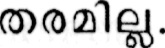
തരമില്ല.
